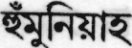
হুঁমুনিয়াহ
